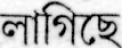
লাগিছে
